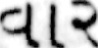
વાર
